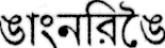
ঙাংনরিঙৈ
